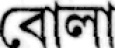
বোলা
